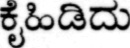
ಕೈಹಿಡಿದು
